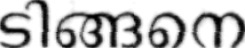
ടിങ്ങനെ
